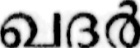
ഖദര്‍
